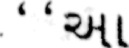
"આ
